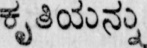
ಕೃತಿಯನ್ನು
